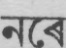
নৰে
